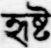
হৃষ্ট
